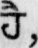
ਹੈ,
